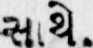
સાથે.
